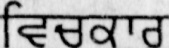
ਵਿਚਕਾਰ
